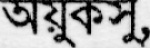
অয়ুকসু,
